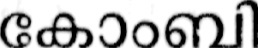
കോംബി
